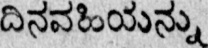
ದಿನವಹಿಯನ್ನು
